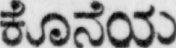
ಕೊನೆಯ
